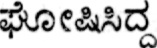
ಘೋಷಿಸಿದ್ದ
